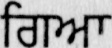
ਗਿਆ
